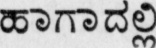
ಹಾಗಾದಲ್ಲಿ
